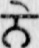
ਨੇ
